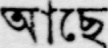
আছে
